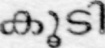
കൂടി
